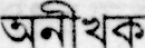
অনীখক
